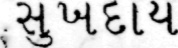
સુખદાય
